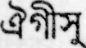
ঐগীসু
